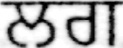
ਲਗ
